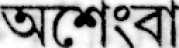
অশেংবা
